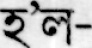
হ'ল-
